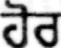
ਹੋਰ
